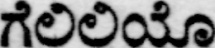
ಗೆಲಿಲಿಯೊ
